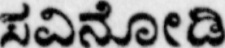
ಸವಿನೋಡಿ
